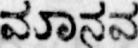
ಮಾನವ
